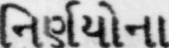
નિર્ણયોના
